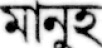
মানুহ
